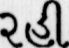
રહી
